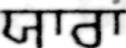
ਯਾਰਾਂ
